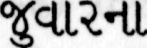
જુવારના
